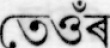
তেওঁৰ
